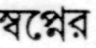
স্বপ্নের
